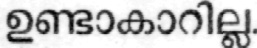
ഉണ്ടാകാറില്ല.
